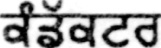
ਕੰਡੱਕਟਰ
